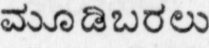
ಮೂಡಿಬರಲು
